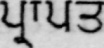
ਪ੍ਰਾਪਤ
